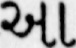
આ
